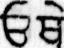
ਓਥੇ
